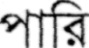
পারি
